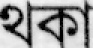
থকা
